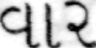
વાર
